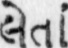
લેતાં
